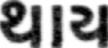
થાય
